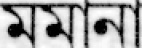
মমানা
